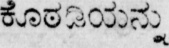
ಕೊಠಡಿಯನ್ನು
